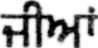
ਜੀਆਂ
